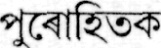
পুৰোহিতক
